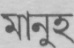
মানুহ
